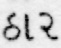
ઠાર
